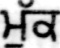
ਮੁੱਕ
